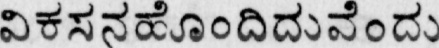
ವಿಕಸನಹೊಂದಿದುವೆಂದು
